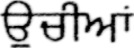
ਉਚੀਆਂ
